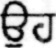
ਉਹ
